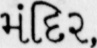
મંદિર,
